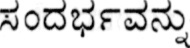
ಸಂದರ್ಭವನ್ನು
